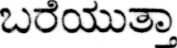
ಬರೆಯುತ್ತಾ
